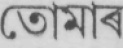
তোমাৰ
